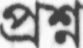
প্রশ্ন
